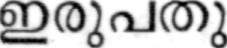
ഇരുപതു
